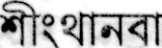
শীংথানবা
